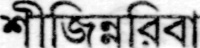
শীজিন্নরিবা
